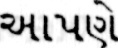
આપણે
